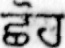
ਛੋਹ
